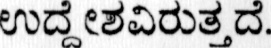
ಉದ್ದೇಶವಿರುತ್ತದೆ.
